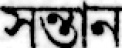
সন্তান
